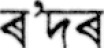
ৰ'দৰ
